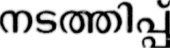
നടത്തിപ്പ്
